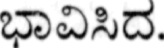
ಭಾವಿಸಿದ.
